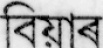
বিয়াৰ
